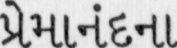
પ્રેમાનંદના
